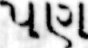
પણ
